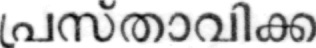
പ്രസ്താവിക്ക
